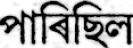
পাৰিছিল
